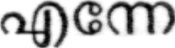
എന്നേ
